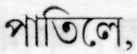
পাতিলে,
